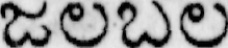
ಜಲಬಲ
